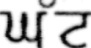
ਘੱਟ
